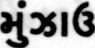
મુંઝાઉ
